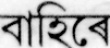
বাহিৰে
